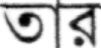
তার
